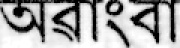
অৱাংবা
